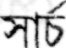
সার্চ
